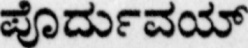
ಪೊರ್ದುವಯ್
